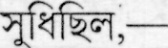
সুধিছিল,-
